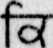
ਕਿ
